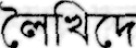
লৈখিদে
